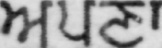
ਅਪਣਾ
